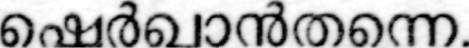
ഷെര്‍ഖാന്‍തന്നെ.
